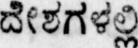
ದೇಶಗಳಲ್ಲಿ
